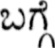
ಬಗ್ಗೆ
